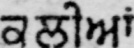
ਕਲੀਆਂ
